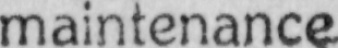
maintenance
